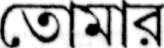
তোমার
